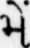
મેં
